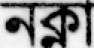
নক্না
